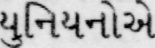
યુનિયનોએ
